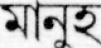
মানুহ
